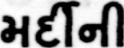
મર્દીની
